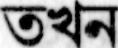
তখন
